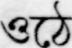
ওঠে
